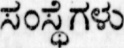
ಸಂಸ್ಥೆಗಳು
